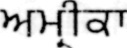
ਅਮ੍ਰੀਕਾ
